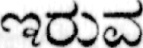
ಇರುವ
